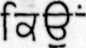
ਕਿਉਂ
